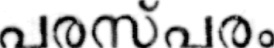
പരസ്പരം
